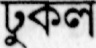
ঢুকল
